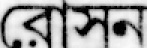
রোসন
